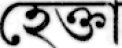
হেক্তা
